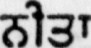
ਨੀਤਾ
